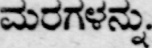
ಮರಗಳನ್ನು.
